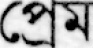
প্রেম
